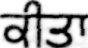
ਕੀਤਾ
